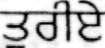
ਤੁਰੀਏ
